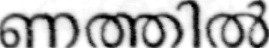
ണത്തില്‍
